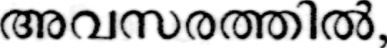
അവസരത്തില്‍,
